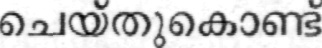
ചെയ്തുകൊണ്ട്
